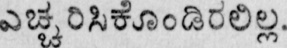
ಎಚ್ಚರಿಸಿಕೊಂಡಿರಲಿಲ್ಲ.
